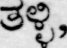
ತಳ್ಳಿ,
